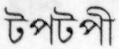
টপটপী
